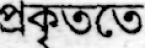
প্রকৃততে
